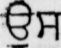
ਉਸ
